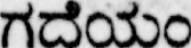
ಗದೆಯಂ
